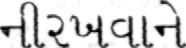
નીરખવાને
